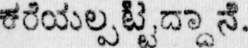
ಕರೆಯಲ್ಪಟ್ಟಿದ್ದಾನೆ.
